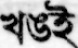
খঙই
